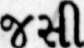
જસી
